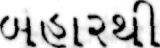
બહારથી
